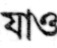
যাও
